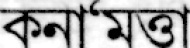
কনা‘মত্তা
